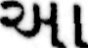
આ
